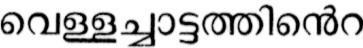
വെള്ളച്ചാട്ടത്തിന്റെ
